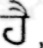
ਹੈ,
